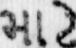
માટે
